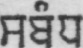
ਸਬੰਧ
